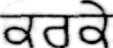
ਕਰਕੇ
